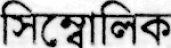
সিম্বোলিক
